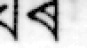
ঘৰ
